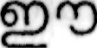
ഈ
